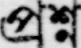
প্রশ্ন
